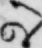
જે
